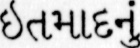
ઇતમાદનું
